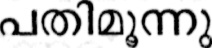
പതിമൂന്നു
